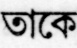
তাকে
